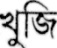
খুজি
